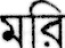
মরি
